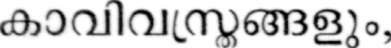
കാവിവസ്ത്രങ്ങളും,
